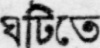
ঘটিতে
